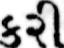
કરી
